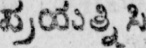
ಪ್ರಯತ್ನಿಸಿ
